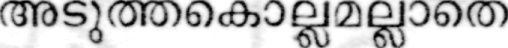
അടുത്തകൊല്ലമല്ലാതെ
